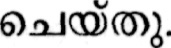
ചെയ്തു.
